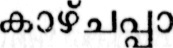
കാഴ്ചപ്പാ
